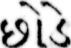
છોડે
